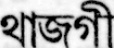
থাজগী
